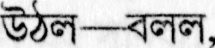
উঠল–বলল,
